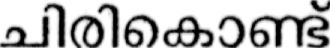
ചിരികൊണ്ട്
